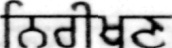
ਨਿਰੀਖਣ
